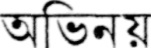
অভিনয়
